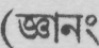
(জ্ঞানং
